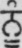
ਨੂੰ
